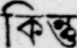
কিন্তু
